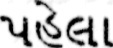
પહેલા
